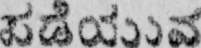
ಪಡೆಯುವ
